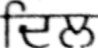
ਦਿਲ
